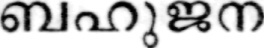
ബഹുജന
